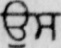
ਉਸ
